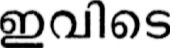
ഇവിടെ
